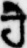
ਹੈ
